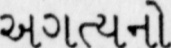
અગત્યનો
